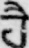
ਹੈ
